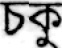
চকু
